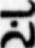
ಸ
